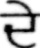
ਦੇ
